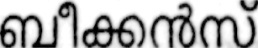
ബീക്കന്‍സ്
